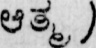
ಆತ್ಮ)
